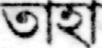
তাহা
